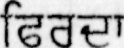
ਫਿਰਦਾ
